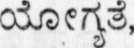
ಯೋಗ್ಯತೆ,
